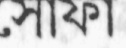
সোফা
